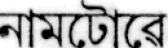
নামটোৱে
